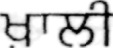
ਖ਼ਾਲੀ
